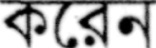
করেন
